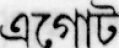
এগোট
